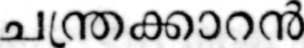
ചന്ത്രക്കാറന്‍
